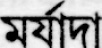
মর্যাদা
